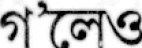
গ'লেও
